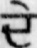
ਦੇ
